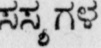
ಸಸ್ಯಗಳ
